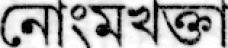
নোংমখক্তা
